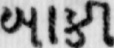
બાકી
